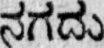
ನಗದು
